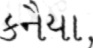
કનૈયા,
